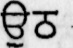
ਉਠ
